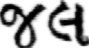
જલ
